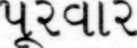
પૂરવાર
